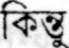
কিন্তু
